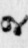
જ
